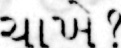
ચાખે?
